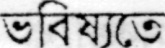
ভবিষ্যতে
